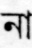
না
